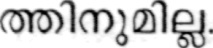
ത്തിനുമില്ല.
